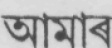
আমাৰ
